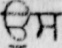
ਉਸ
